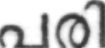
പരി
